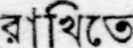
রাখিতে
